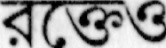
রক্তেও
